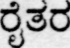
ರೈತರ
